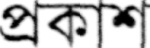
প্রকাশ
